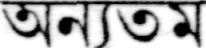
অন্যতম
